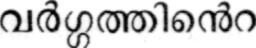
വര്‍ഗ്ഗത്തിന്റെ
